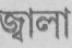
জ্বালা
